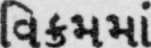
વિક્રમમાં
